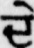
ਦੇ
